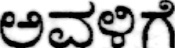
ಅವಳಿಗೆ
